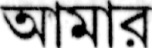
আমার
